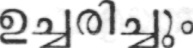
ഉച്ചരിച്ചും
